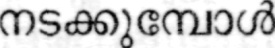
നടക്കുമ്പോള്‍
